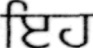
ਇਹ
